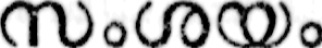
സംശയം
